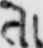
તો
